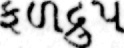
ફળદ્રુપ
